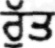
ਰੁੱਤ
